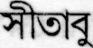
সীতাবু
